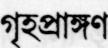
গৃহপ্রাঙ্গণ
